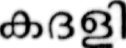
കദളി
